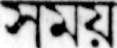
সময়
